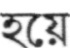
হয়ে
